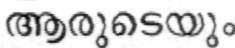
ആരുടെയും
